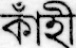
কাঁহী
